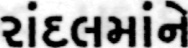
રાંદલમાંને
